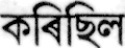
কৰিছিল
